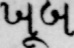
ખૂબ
